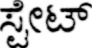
ಸ್ಟೇಟ್
